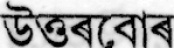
উত্তৰবোৰ
